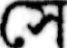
সে
